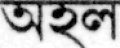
অহল
